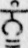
ਨੂੰ
